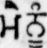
ਮੈਨੂੰ
